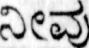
ನೀವು
